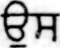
ਉਸ
